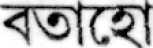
বতাহো
